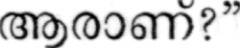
ആരാണ്?"
